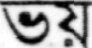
ভয়
